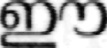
ഈ
